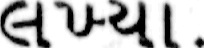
લખ્યા.
